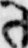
તે
